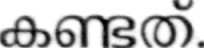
കണ്ടത്.
